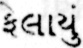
ફેલાયું
